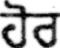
ਹੋਰ
